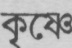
কৃষ্ণে
